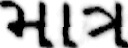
માત્ર
